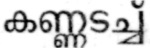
കണ്ണടച്ച്
